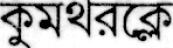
কুমথরক্লে
